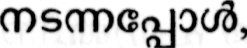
നടന്നപ്പോള്‍,
